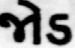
જોડ
